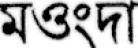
মওংদা
